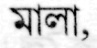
মালা,
